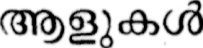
ആളുകള്‍
